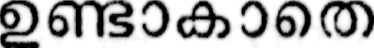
ഉണ്ടാകാതെ
